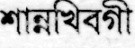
শান্নখিবগী
